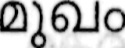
മുഖം
